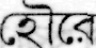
হৌরে
